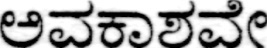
ಅವಕಾಶವೇ
